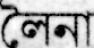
লৈনা
